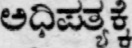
ಅಧಿಪತ್ಯಕ್ಕೆ
